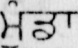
ਮੁੰਡਾ
